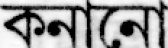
কনানো
